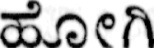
ಹೋಗಿ
